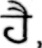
ਹੈ,
